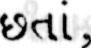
છતાં,
